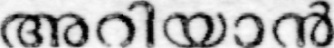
അറിയാന്‍
